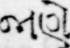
જાણે
